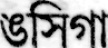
ঙসিগা
